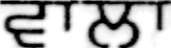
ਵਾਲਾ
